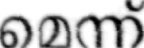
മെന്ന്
